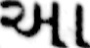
આ
